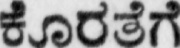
ಕೊರತೆಗೆ
